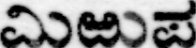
ಮಿಱುಪ
